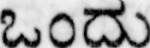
ಒಂದು
